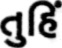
તુહિં
